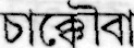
চাক্কৌবা
